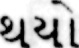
થયો
